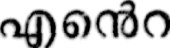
എന്റെ
